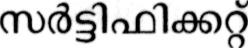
സര്‍ട്ടിഫിക്കറ്റ്
